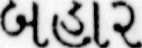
બહાર
